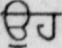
ਉਹ
